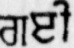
ਗਈ
